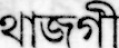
থাজগী
